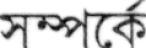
সম্পর্কে
